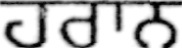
ਹਰਾਨ
